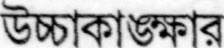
উচ্চাকাঙ্ক্ষার
